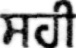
ਸਹੀ
